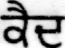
ਕੈਦ
